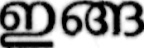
ഇങ്ങ
